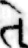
તે
